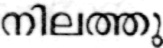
നിലത്തു
